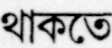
থাকতে
